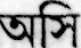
অসি
